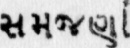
સમજણાં
